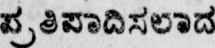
ಪ್ರತಿಪಾದಿಸಲಾದ
